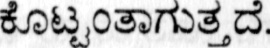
ಕೊಟ್ಟಂತಾಗುತ್ತದೆ.
